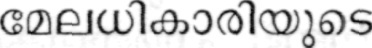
മേലധികാരിയുടെ
